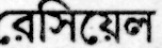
রেসিয়েল
